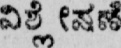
ವಿಶ್ಲೇಷಣೆ
